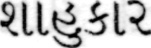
શાહુકાર
